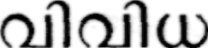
വിവിധ
